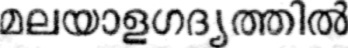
മലയാളഗദ്യത്തില്‍
